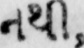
નથી,
